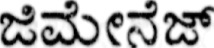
ಜಿಮೇನೆಚ್
